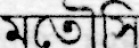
মতৌসি
